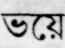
ভয়ে
